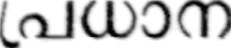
പ്രധാന
